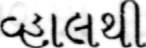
વ્હાલથી
